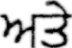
ਅਤੇ
